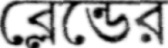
ব্লেন্ডের
